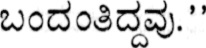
ಬಂದಂತಿದ್ದವು."
